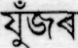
যুঁজৰ
